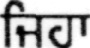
ਜਿਹਾ
